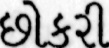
છોકરી
